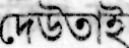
দেউতাই
